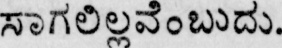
ಸಾಗಲಿಲ್ಲವೆಂಬುದು.
